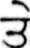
ਤੇ
